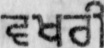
ਵਖਰੀ
